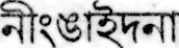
নীংঙাইদনা
